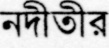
নদীতীর
